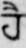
ਹੈ
